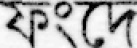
ফংদে
